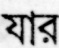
যার
